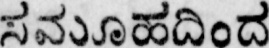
ಸಮೂಹದಿಂದ
